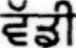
ਵੱਡੀ
